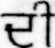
ਦੀ
